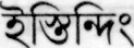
ইস্তিন্দিং
